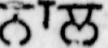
ਨਾਲ
